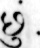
છું.
